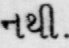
નથી.
